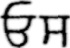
ਓਸ
